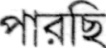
পারছি
